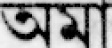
অমা
